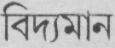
বিদ্যমান
